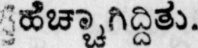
ಹೆಚ್ಚಾಗಿದ್ದಿತು.
